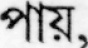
পায়,
